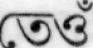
তেওঁ
